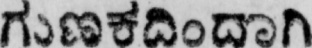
ಗುಣಕದಿಂದಾಗಿ
